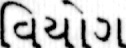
વિયોગ
